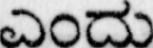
ಎಂದು
